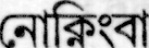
নোক্নিংবা
